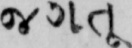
જગતૂ
